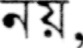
নয়,
